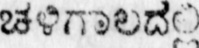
ಚಳಿಗಾಲದಲ್ಲಿ
